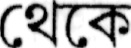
থেকে
